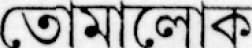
তোমালোক
